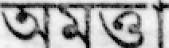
অমত্তা
